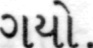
ગયો.
